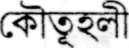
কৌতূহলী
